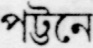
পট্টনে
